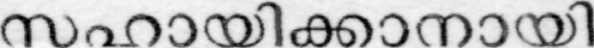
സഹായിക്കാനായി
